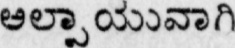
ಅಲ್ಪಾಯುವಾಗಿ
